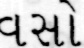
વસો
